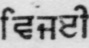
ਵਿਜਈ
